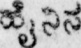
ಹೈನಿನ
